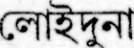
লোইদুনা
